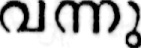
വന്നു
